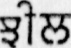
ਝੀਲ
